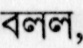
বলল,
